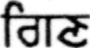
ਗਿਣ
